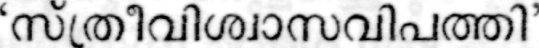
‘സ്ത്രീവിശ്വാസവിപത്തി’
